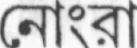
নোংরা
